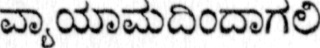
ವ್ಯಾಯಾಮದಿಂದಾಗಲಿ
